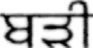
ਬੜੀ
